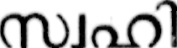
സ്വഹി
